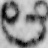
ಆ
